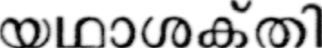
യഥാശക്തി
